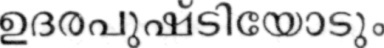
ഉദരപുഷ്ടിയോടും
